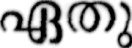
ഏതു
